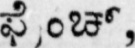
ಫ್ರೆಂಚ್,
